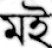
মই
